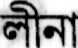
লীনা
